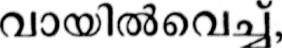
വായില്‍വെച്ച്,
